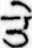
ਤੇ
